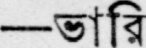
—ভারি
